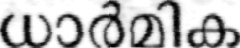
ധാര്‍മിക
